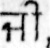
ਜੀ,
